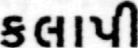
કલાપી
